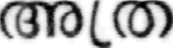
അത്ര
